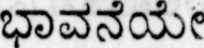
ಭಾವನೆಯೇ
